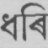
ধৰি
